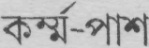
কৰ্ম্ম-পাশ
